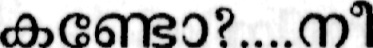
കണ്ടോ?....നീ
